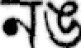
নঙ
